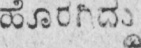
ಹೊರಗಿದ್ದು
